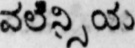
ವಲೆನ್ಸಿಯ
